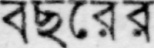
বছরের
